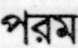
পরম
